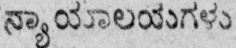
ನ್ಯಾಯಾಲಯಗಳು
